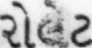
રોલેટ
